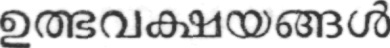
ഉത്ഭവക്ഷയങ്ങള്‍
